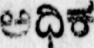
ಅಧಿಕ
